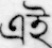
এই
